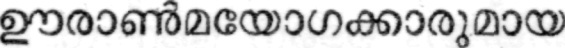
ഊരാണ്‍മയോഗക്കാരുമായ
